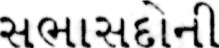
સભાસદોની
